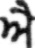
ਐ
